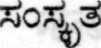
ಸಂಸ್ಕೃತ
